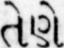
તેણે
